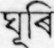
ঘূৰি
